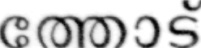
ത്തോട്
